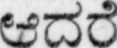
ಆದರೆ
